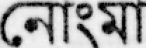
নোংমা
